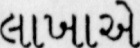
લાખાએ
